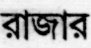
রাজার
